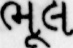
ભૂલ
